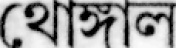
থোঙ্গাল
